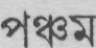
পঞ্চম
